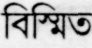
বিস্মিত
